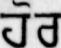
ਹੋਰ
